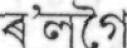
ৰ'লগৈ
